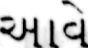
આવે
